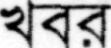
খবর
